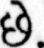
છે.
